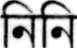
নিনি
